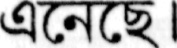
এনেছে।
